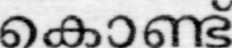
കൊണ്ട്
